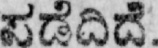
ಪಡೆದಿದೆ.
